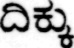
ದಿಕ್ಕು
